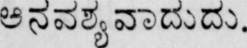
ಅನವಶ್ಯವಾದುದು.
